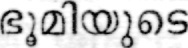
ഭൂമിയുടെ
